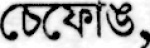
চেফোঙ,
